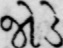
જોડે
